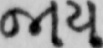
જાય
